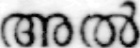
അല്‍
